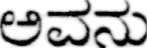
ಅವನು
